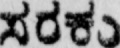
ಸರಕು
